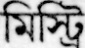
মিস্ট্রি
